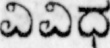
ವಿವಿಧ
